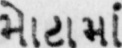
મોટામાં
